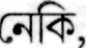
নেকি,
